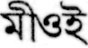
মীওই
